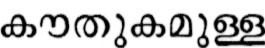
കൌതുകമുള്ള
